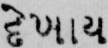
દેખાય
